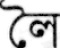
লৈ
